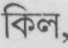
কিল,
